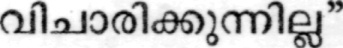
വിചാരിക്കുന്നില്ല”
